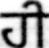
ਹੀ
